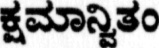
ಕ್ಷಮಾನ್ವಿತಂ
